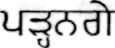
ਪੜ੍ਹਨਗੇ
